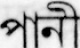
পানী
